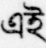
এই
